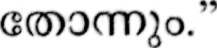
തോന്നും.”
